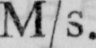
M/s.
